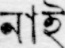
নাই
